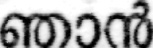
ഞാന്‍
